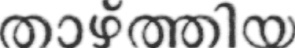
താഴ്ത്തിയ
